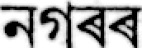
নগৰৰ
